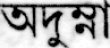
অদুম্না
